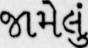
જામેલું
